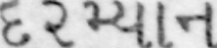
દરમ્યાન
